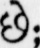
છે;
